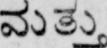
ಮತ್ತು
